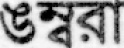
ঙম্বরা
